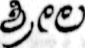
ಶ್ರೀಲ
